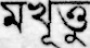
মখূত্তু
